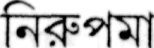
নিরুপমা
